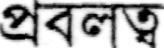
প্রবলত্ব
